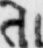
તો
